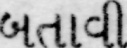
બતાવી
